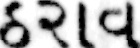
ઠરાવ
